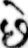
છે
